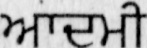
ਆਦਮੀ
